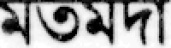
মতমদা
